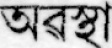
অৱস্হা
